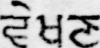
ਵੇਖਣ
